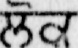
ਲੋਕ
